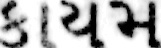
કાયમ
